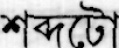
শব্দটো
